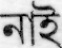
নাই
